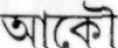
আকৌ
